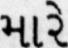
મારે
